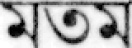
মতম
